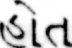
હોત
